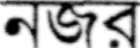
নজর
